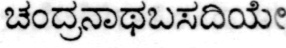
ಚಂದ್ರನಾಥಬಸದಿಯೇ
